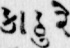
કાઠુરે
